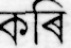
কৰি
